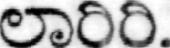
ಲಾರಿರಿ.
